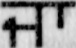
ਜਾ
